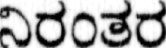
ನಿರಂತರ
